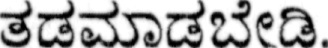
ತಡಮಾಡಬೇಡಿ.
